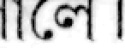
নালে
